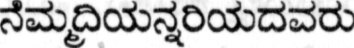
ನೆಮ್ಮದಿಯನ್ನರಿಯದವರು
